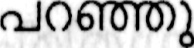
പറഞ്ഞു
